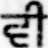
ਵੀ
